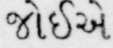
જોઈએ
